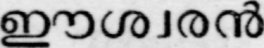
ഈശ്വരന്‍
